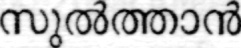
സുല്‍ത്താന്‍
